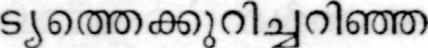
ട്യത്തെക്കുറിച്ചറിഞ്ഞ
